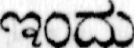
ಇಂದು
